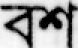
বশ
